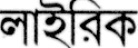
লাইরিক
